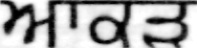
ਆਕੜ
